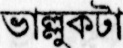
ভাল্লুকটা
